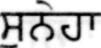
ਸੁਨੇਹਾ
